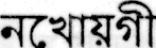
নখোয়গী
